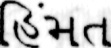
હિંમત
